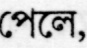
পেলে,
